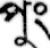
পুং
